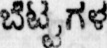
ಬೆಟ್ಟಗಳ
